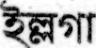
ইল্লগা
